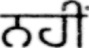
ਨਹੀਂ
